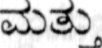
ಮತ್ತು
